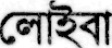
লোইবা
